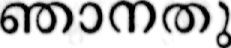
ഞാനതു
